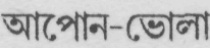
আপোন-ভোলা
